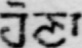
ਹੋਣਾ
